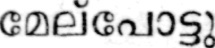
മേല്പോട്ടു
